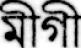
মীগী
